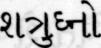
શત્રુધ્નો
